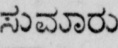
ಸುಮಾರು
